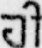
ਹੀ
